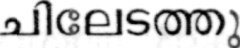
ചിലേടത്തു
